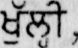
ਖੁੱਲ੍ਹੀ,
